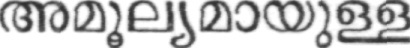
അമൂല്യമായുള്ള
